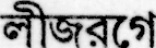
লীজরগে
